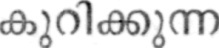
കുറിക്കുന്ന
